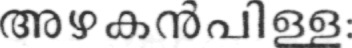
അഴകന്‍പിള്ള:
